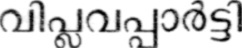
വിപ്ലവപ്പാര്‍ട്ടി
